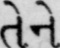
તેને
